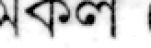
অকল
